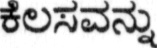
ಕೆಲಸವನ್ನು
